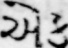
એક
